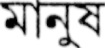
মানুষ
